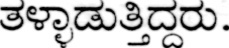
ತಳ್ಳಾಡುತ್ತಿದ್ದರು.
